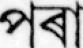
পৰা
